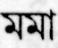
মমা
